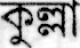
কুল্লা
